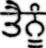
ਤੈਨੂੰ
